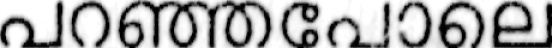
പറഞ്ഞപോലെ
